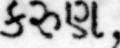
કરુણ,
